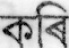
কৰি
